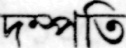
দম্পতি
